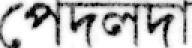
পেদলদা
